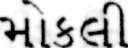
મોકલી
